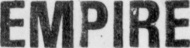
EMPIRE
